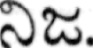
ನಿಜ.
